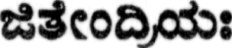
ಜಿತೇಂದ್ರಿಯಃ
